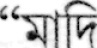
“মাদি
